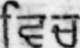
ਵਿਚ
